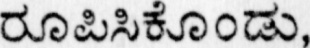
ರೂಪಿಸಿಕೊಂಡು,
